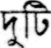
দুটি
